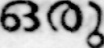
ഒരു
